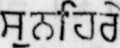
ਸੁਨਹਿਰੇ
